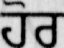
ਹੋਰ
